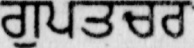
ਗੁਪਤਚਰ
